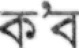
ক'ব
